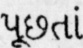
પૂછતાં
